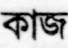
কাজ
